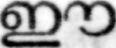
ഈ
